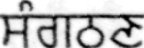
ਸੰਗਠਣ
